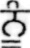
ਨੂੰ
